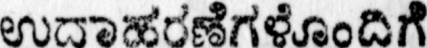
ಉದಾಹರಣೆಗಳೊಂದಿಗೆ
